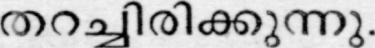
തറച്ചിരിക്കുന്നു.
